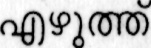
എഴുത്ത്
